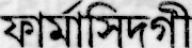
ফার্মাসিদগী
